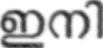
ഇനി
